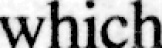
which
